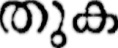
തുക
